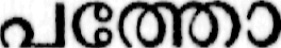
പത്തോ
